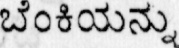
ಬೆಂಕಿಯನ್ನು
